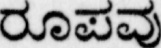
ರೂಪವು
